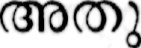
അതു
